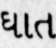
ઘાત
